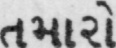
તમારો
